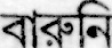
বারুনি
